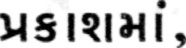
પ્રકાશમાં,
